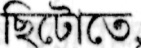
ছিটোতে,
